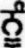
ਨੂੰ
